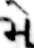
મે
